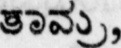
ತಾಮ್ರ,
